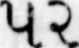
પર
